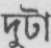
দুটা
